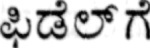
ಫಿಡೆಲ್ಗೆ
